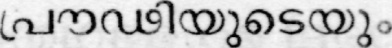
പ്രൌഢിയുടെയും
